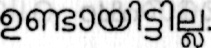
ഉണ്ടായിട്ടില്ല.
